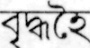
বৃদ্ধহৈ
